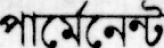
পার্মেনেন্ট
